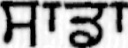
ਸਾਡਾ
